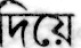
দিয়ে
